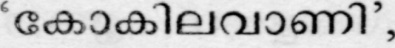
'കോകിലവാണി',
